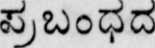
ಪ್ರಂಬಂಧದ
